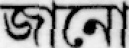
জানো
